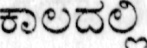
ಕಾಲದಲ್ಲಿ
